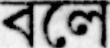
বলে
